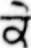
ਕੇ
